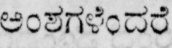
ಅಂಶಗಳೆಂದರೆ
